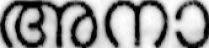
അനാ
